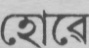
হোৱে
